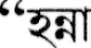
“হন্না
